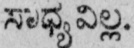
ಸಾಧ್ಯವಿಲ್ಲ.
